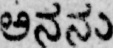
ಅನನು
